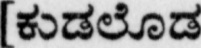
[ಕುಡಲೊಡ
